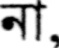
না,
